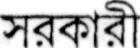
সরকারী
